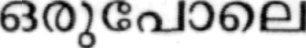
ഒരുപോലെ
